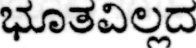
ಭೂತವಿಲ್ಲದ
